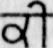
ਕੀ
